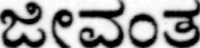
ಜೀವಂತ
